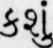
કશું
